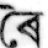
ৰৈ
